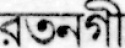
রতনগী
